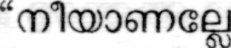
“നീയാണല്ലേ
